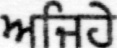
ਅਜਿਹੇ
